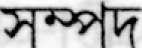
সম্পদ
